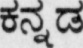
ಕನ್ನಡ
